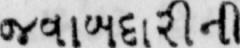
જવાબદારીની
